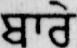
ਬਾਰੇ
